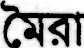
মৈরা
